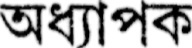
অধ্যাপক
